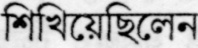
শিখিয়েছিলেন
